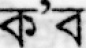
ক'ব
